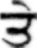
ਤੇ
